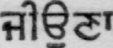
ਜੀਉਣਾ
